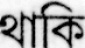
থাকি
